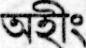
অহীং
